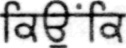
ਕਿਉਂਕਿ
